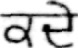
ਕਦੇ
